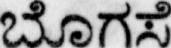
ಬೊಗಸೆ
